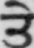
ਤੇ
